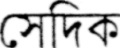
সেদিক
